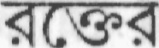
রক্তের
